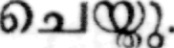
ചെയ്തു.
